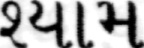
શ્યામ
